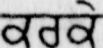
ਕਰਕੇ
